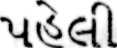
પહેલી
